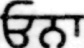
ਓਨਾ
